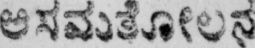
ಅಸಮತೋಲನ
